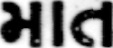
માત
